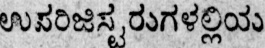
ಉಪರಿಜಿಸ್ಟರುಗಳಲ್ಲಿಯ
